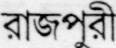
রাজপুরী
